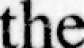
the
